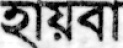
হায়বা
